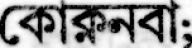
কোক্ননবা;
